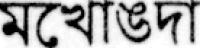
মখোঙদা
